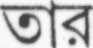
তার
